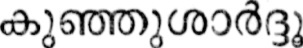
കുഞ്ഞുശാര്‍ദ്ദൂ
